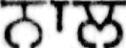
ਨਾਲ
